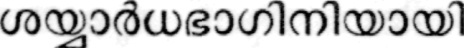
ശയ്യാര്‍ധഭാഗിനിയായി
